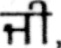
ਜੀ,
